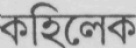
কহিলেক
